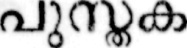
പുസ്തക
